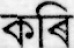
কৰি
